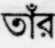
তাঁর
